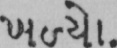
ખળ્યો.
